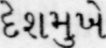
દેશમુખે
